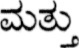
ಮತ್ತು
